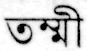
তম্মী
